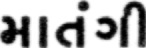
માતંગી
